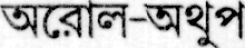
অরোল-অথুপ
